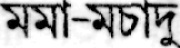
মমা-মচাদু
